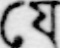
যে
